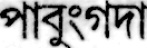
পাবুংগদা
